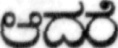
ಆದರೆ
